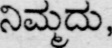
ನಿಮ್ಮದು,
